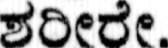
ಶರೀರೇ.
